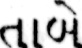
તાબે
